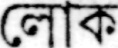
লোক
